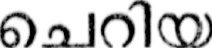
ചെറിയ
